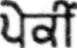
ਪੇਕੀਂ
